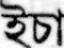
ইচা
